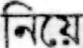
নিয়ে
